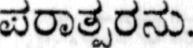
ಪರಾತ್ಪರನು.
